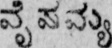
ವೈಷಮ್ಯ
